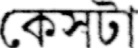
কেসটা
